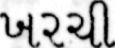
ખરચી
